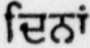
ਦਿਨਾਂ
